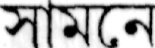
সামনে
